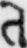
તે
